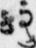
કરું
